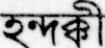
হন্দক্কী
